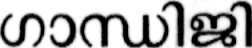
ഗാന്ധിജി
